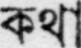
কথা
